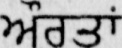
ਔਰਤਾਂ
